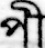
পী
